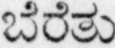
ಬೆರೆತು
